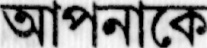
আপনাকে
